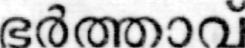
ഭര്‍ത്താവ്
